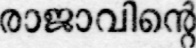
രാജാവിന്റെ
